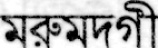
মরুমদগী
